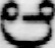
ಆ
